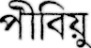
পীবিয়ু
